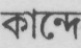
কান্দে
